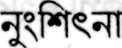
নুংশিৎনা
